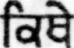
ਕਿਥੇ
